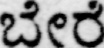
ಬೇರೆ
